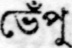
ভেঁপু
